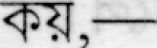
কয়,-
